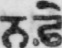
ਨਫ਼ੇ
